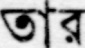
তার
